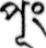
পূং
